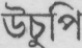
উচুপি
